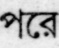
পরে
